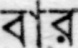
বার
